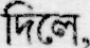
দিলে,
